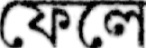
ফেলে
